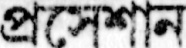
প্রসেশান
